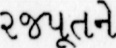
રજપૂતને
